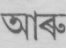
আৰু
